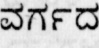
ವರ್ಗದ
